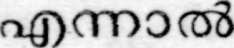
എന്നാല്‍
